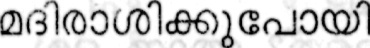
മദിരാശിക്കുപോയി
